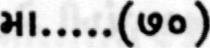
મા.....(૭૦)
